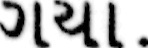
ગયા.
